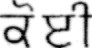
ਕੋਈ
